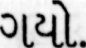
ગયો.
